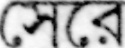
সেরে
